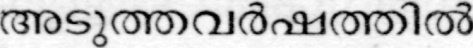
അടുത്തവര്‍ഷത്തില്‍
